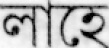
লাহে
